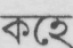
কহে
